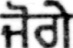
ਜੋਗੇ
